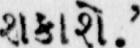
શકાશે.'
